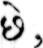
છે,
